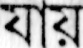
যায়
